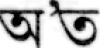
অ'ত
